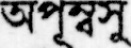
অপূম্বসু
